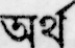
অর্থ
